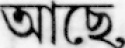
আছে,
